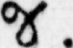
જ.
